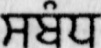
ਸਬੰਧ
